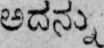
ಅದನ್ನು
